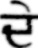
ਦੇ
